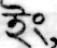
ইং,
